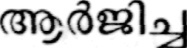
ആര്‍ജിച്ച
